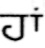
ਹਾਂ
